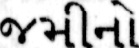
જમીનો
